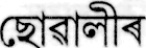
ছোৱালীৰ
